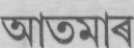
আতমাৰ
